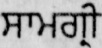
ਸਾਮਗ੍ਰੀ
